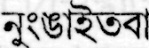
নুংঙাইতবা
